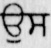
ਉਸ
